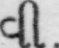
વી.
